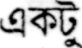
একটু
